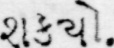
શ્ક્યો.
